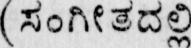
(ಸಂಗೀತದಲ್ಲಿ
